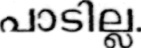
പാടില്ല.
